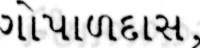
ગોપાળદાસ,
